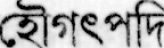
হৌগৎপদি
